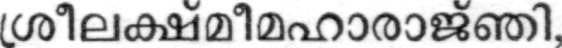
ശ്രീലക്ഷ്മീമഹാരാജ്ഞി,
